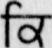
ਕਿ
